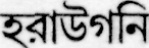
হরাউগনি
